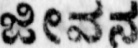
ಜೀವನ
